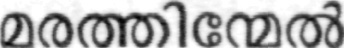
മരത്തിന്മേല്‍
